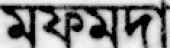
মফমদা
